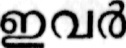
ഇവര്‍
